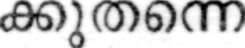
ക്കുതന്നെ
